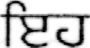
ਇਹ
